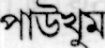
পাউখুম
